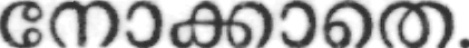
നോക്കാതെ.
